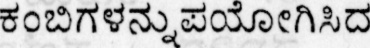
ಕಂಬಿಗಳನ್ನುಪಯೋಗಿಸಿದ
